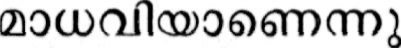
മാധവിയാണെന്നു
